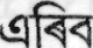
এৰিব
